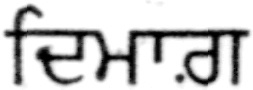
ਦਿਮਾਗ਼
